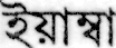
ইয়াম্বা
